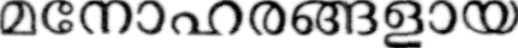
മനോഹരങ്ങളായ
